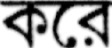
করে
